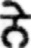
ਨੇ
